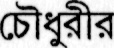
চৌধুরীর
